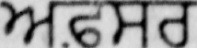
ਅਫ਼ਸਰ
